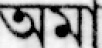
অমা
